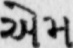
એમ
